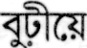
বুঢ়ীয়ে
